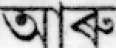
আৰু
